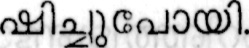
ഷിച്ചുപോയി.
